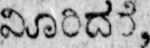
ಮಿರಿದರ,
